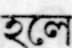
হলে
